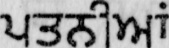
ਪਤਨੀਆਂ
